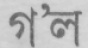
গ'ল
